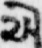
એ
